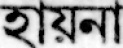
হায়না
